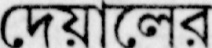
দেয়ালের
